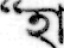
“হা
